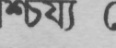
শ্চয্য
